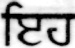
ਇਹ
